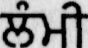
ਲੰਮੀ
